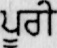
ਪੂਰੀ
